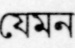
যেমন
